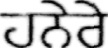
ਹਨੇਰੇ
